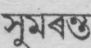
সুমৰন্ত
